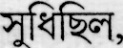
সুধিছিল,
